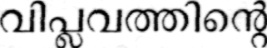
വിപ്ലവത്തിന്റെ
